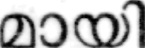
മായി
